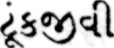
ટૂંકજીવી
